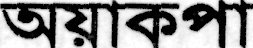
অয়াকপা
